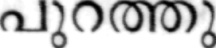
പുറത്തു
